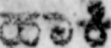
ಹಾಕಿ
